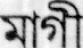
মাগী
